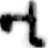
ન
